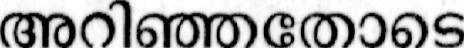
അറിഞ്ഞതോടെ
